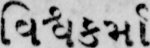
વિશ્વકર્મી
